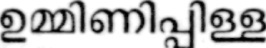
ഉമ്മിണിപ്പിള്ള
